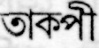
তাকপী
